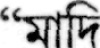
“মাদি
